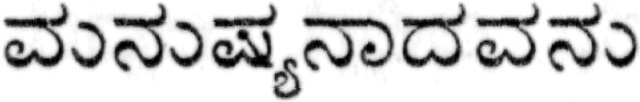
ಮನುಷ್ಯನಾದವನು
